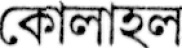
কোলাহল
